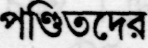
পণ্ডিতদের
